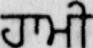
ਹਾਮੀ
